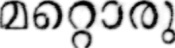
മറ്റൊരു
